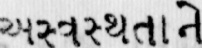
અસ્વસ્થતાને
